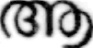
ആ
